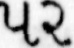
પર
